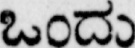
ಒಂದು
